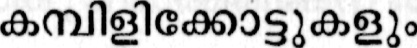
കമ്പിളിക്കോട്ടുകളും
